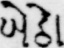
બેઠો
